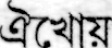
ঐখোয়
